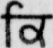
ਕਿ
